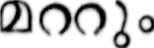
മററും
